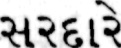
સરદારે
